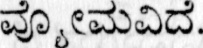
ವ್ಯೋಮವಿದೆ.
